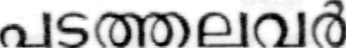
പടത്തലവര്‍
